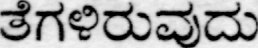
ತೆಗಳಿರುವುದು
